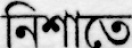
নিশাতে
